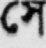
সে
